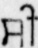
ਸੀ
